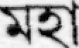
মহা
